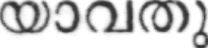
യാവതു
